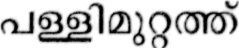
പള്ളിമുറ്റത്ത്
